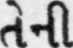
તેની
